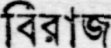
বিরাজ
